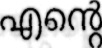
എന്റെ
